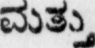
ಮತ್ತು
